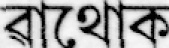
ৱাথোক
